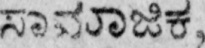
ಸಾಮಾಜಿಕ,
